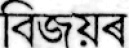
বিজয়ৰ
